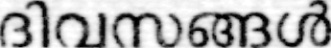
ദിവസങ്ങള്‍
